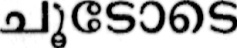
ചൂടോടെ
